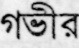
গভীর
